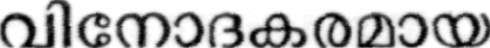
വിനോദകരമായ
